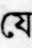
যে
